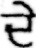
ਦੇ
